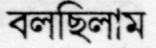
বলছিলাম
